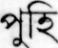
পুহি
